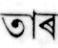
তাৰ
